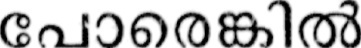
പോരെങ്കില്‍
